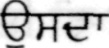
ਉਸਦਾ
